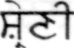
ਸ਼੍ਰੇਣੀ
